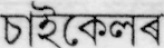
চাইকেলৰ
